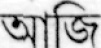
আজি
